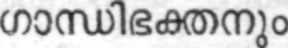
ഗാന്ധിഭക്തനും
